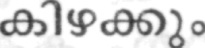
കിഴക്കും
